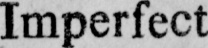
Imperfect
